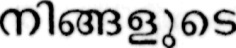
നിങ്ങളുടെ
